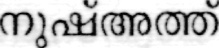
നുഷ്അത്ത്
